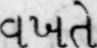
વખતે
